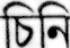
চিনি
